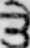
ਤੇ
